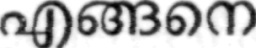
എങ്ങനെ
